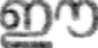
ഈ
